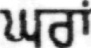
ਘਰਾਂ
